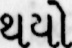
થયો
